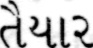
તૈયાર
